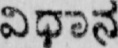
ವಿಧಾನ
